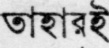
তাহারই
